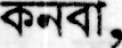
কনবা,
